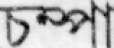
চম্পা
